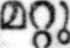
മറ്റു
